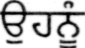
ਉਹਨੂੰ
